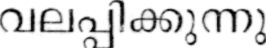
വലപ്പിക്കുന്നു
